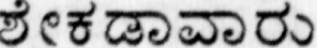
ಶೇಕಡಾವಾರು
